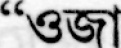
“ওজা
